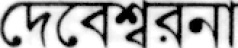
দেবেশ্বরনা
